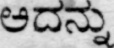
ಅದನ್ನು
